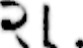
રા.
